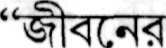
“জীবনের
